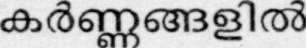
കര്‍ണ്ണങ്ങളില്‍
